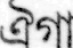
ঐগা
